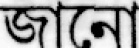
জানো
